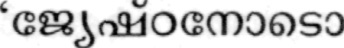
‘ജ്യേഷ്ഠനോടൊ
